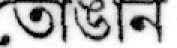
তোঙান
